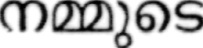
നമ്മുടെ
